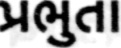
પ્રભુતા
